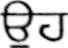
ਉਹ
